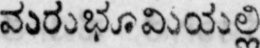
ಮರುಭೂಮಿಯಲ್ಲಿ
